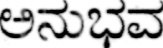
ಅನುಭವ
